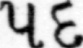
પદ
